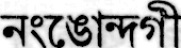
নংঙোন্দগী
